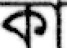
কা
